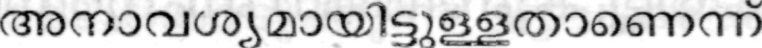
അനാവശ്യമായിട്ടുള്ളതാണെന്ന്
